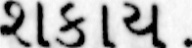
શકાય.
